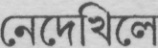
নেদেখিলে
